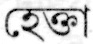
হেক্তা
